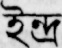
ইন্দ্র
